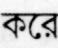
করে
